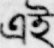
এই
